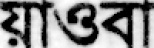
য়াওবা
